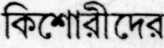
কিশোরীদের
